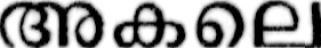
അകലെ
